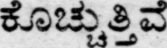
ಕೊಚ್ಚುತ್ತಿವೆ
